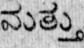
ಮತ್ತು
